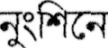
নুংশিনে
